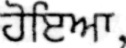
ਹੋਇਆ,
